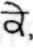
ਕੇ,
